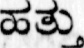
ಹತ್ತು
